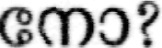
നോ?
